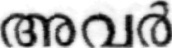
അവര്‍
